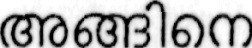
അങ്ങിനെ
